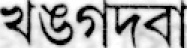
খঙগদবা
